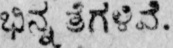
ಭಿನ್ನತೆಗಳಿವೆ.
